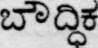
ಬೌದ್ಧಿಕ
